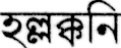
হল্লক্কনি
